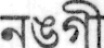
নঙগী
